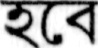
হবে
